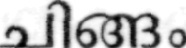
ചിങ്ങം
